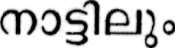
നാട്ടിലും
